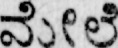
ಮೇಲೆ
